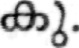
കു.
